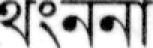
থংননা
